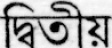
দ্বিতীয়
